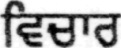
ਵਿਚਾਰ
